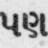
પણ
